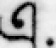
এ.
